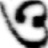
ও
